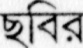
ছবির
